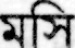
মসি
